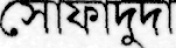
সোফাদুদা
